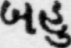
બહુ
